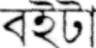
বইটা
